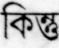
কিন্তু
